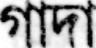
গাদা
